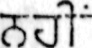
ਨਹੀਂ
